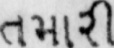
તમારી
